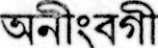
অনীংবগী
